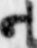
ન
